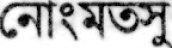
নোংমতসু
